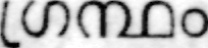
ഗ്രന്ഥം
